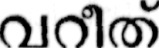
വറീത്
